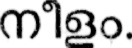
നീളം.
